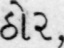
ઠોર,
